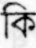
কি
